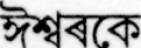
ঈশ্বৰকে
